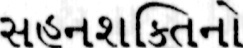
સહનશક્તિનો
